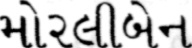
મોરલીબેન
